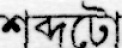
শব্দটো
